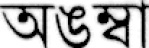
অঙম্বা
